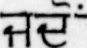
ਜਦੋਂ
